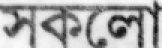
সকলো
